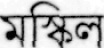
মস্কিল
